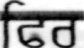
ਫਿਰ
